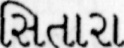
સિતારા
